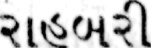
રાહબરી
